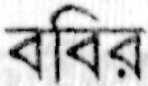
ববির
